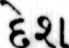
દેશ
